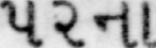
પરના
